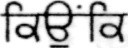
ਕਿਉਂਕਿ
